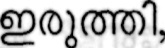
ഇരുത്തി,
